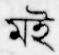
মই
